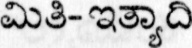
ಮಿತಿ-ಇತ್ಯಾದಿ
